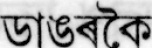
ডাঙৰকৈ
